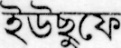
ইউছুফে
